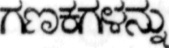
ಗಣಕಗಳನ್ನು
